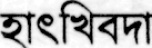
হাৎখিবদা
